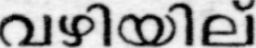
വഴിയില്
